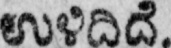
ಉಳಿದಿದೆ.
